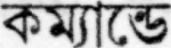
কম্যান্ডে
